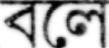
বলে
